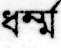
ধর্ম্ম
